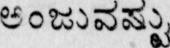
ಅಂಜುವಷ್ಟು
